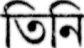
তিনি
